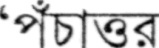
‘পঁচাত্তর
